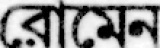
রোমেন
